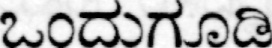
ಒಂದುಗೂಡಿ
